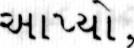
આપ્યો,
